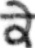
ਕੇ
